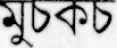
মুচকচ
